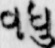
વધુ
